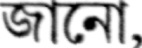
জানো,
